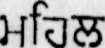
ਮਹਿਲ
